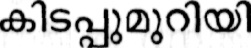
കിടപ്പുമുറിയി
